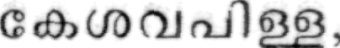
കേശവപിള്ള,
